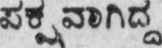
ಪಕ್ಷವಾಗಿದ್ದ
